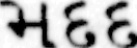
મદદ
